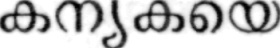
കന്യകയെ
